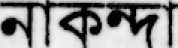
নাকন্দা
